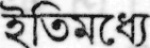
ইতিমধ্যে
